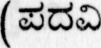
(ಪದವಿ
